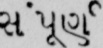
સંપૂર્ણ
